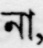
না,
